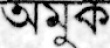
অমুক
